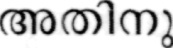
അതിനു
